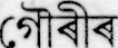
গৌৰীৰ
